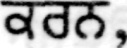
ਕਰਨ,
